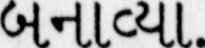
બનાવ્યા.
